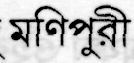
মণিপুরী
